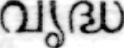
വൃദ്ധ
